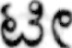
ಟೀ
